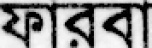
ফারবা
